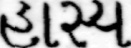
હાસ્ય
